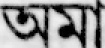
অমা
